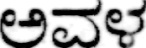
ಅವಳ
